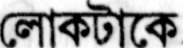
লোকটাকে
